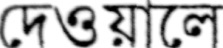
দেওয়ালে
